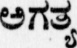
ಅಗತ್ಯ
